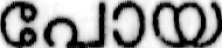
പോയ
